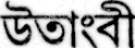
উতাংবী
